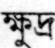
ক্ষুদ্র
